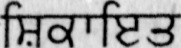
ਸ਼ਿਕਾਇਤ
